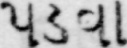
પડવા
